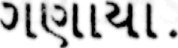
ગણાયા.
